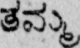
ತಮ್ಮ
